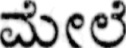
ಮೇಲೆ
